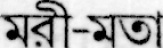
মরী-মতা
